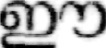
ഈ
